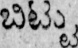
ಬಿಟ್ಟು
